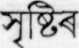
সৃষ্টিৰ
